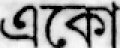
একো
